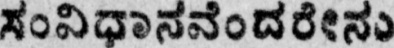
ಸಂವಿಧಾನವೆಂದರೇನು
